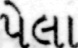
પેલા
